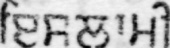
ਇਸਲਾਮੀ
